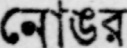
নোঙর
